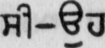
ਸੀ-ਉਹ
